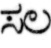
ಸಲ
